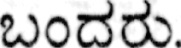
ಬಂದರು.
